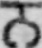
ਨ
